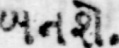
બનશે.
